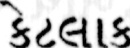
કેટલાક
